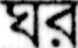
ঘর
